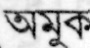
অমুক
